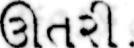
ઊતરી.
